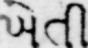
ખેતી
